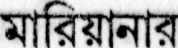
মারিয়ানার
